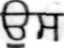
ਉਸ
